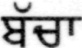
ਬੱਚਾ
